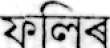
ফলিৰ
